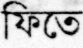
ফিতে
